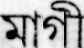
মাগী
